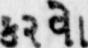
કરવો
